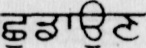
ਛੁਡਾਉਣ
